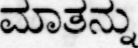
ಮಾತನ್ನು
